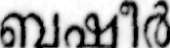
ബഷീര്‍
